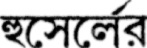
হুসের্লের
